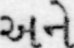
અને
